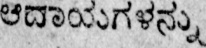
ಆದಾಯಗಳನ್ನು
